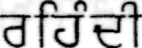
ਰਹਿੰਦੀ
